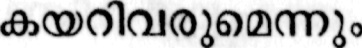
കയറിവരുമെന്നും
